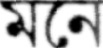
মনে
